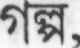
গল্প,
